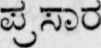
ಪ್ರಸಾರ
